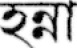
হন্না
